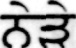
ਨੇੜੇ
